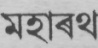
মহাৰথ
